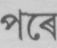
পৰে
